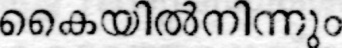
കൈയില്‍നിന്നും
